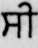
ਸੀ
